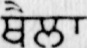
ਥੈਲਾ
